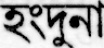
হংদুনা
